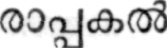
രാപ്പകല്‍
